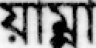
য়াম্না
